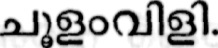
ചൂളംവിളി.
